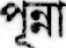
পূন্না
